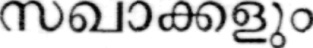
സഖാക്കളും
